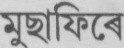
মুছাফিৰে
